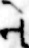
ને
